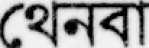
থেনবা
